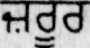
ਜ਼ਰੂਰ
